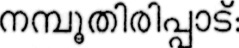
നമ്പൂതിരിപ്പാട്:
